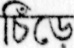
চিঁড়ে
